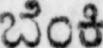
ಬೆಂಕಿ
